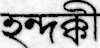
হন্দক্কী
